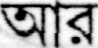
আর
